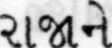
રાજાને
